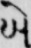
બે
